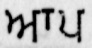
ਆਪ
